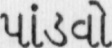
પાંડવો
